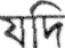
যদি
